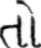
તો
